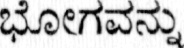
ಭೋಗವನ್ನು
